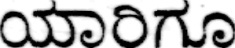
ಯಾರಿಗೂ
